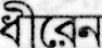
ধীরেন
